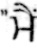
''ਮੈਂ
